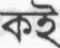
কই
